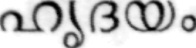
ഹൃദയം
